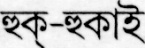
হুক্-হুকাই
